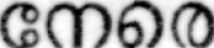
നേരെ
